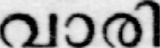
വാരി
